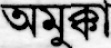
অমুক্কা
